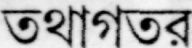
তথাগতর
